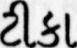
ટીકા
